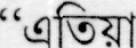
"এতিয়া
